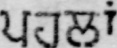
ਪਹਲਾਂ
